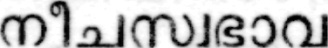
നീചസ്വഭാവ
